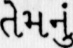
તેમનું
